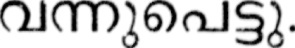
വന്നുപെട്ടു.
